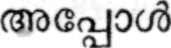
അപ്പോള്‍
